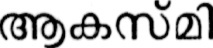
ആകസ്മി
